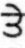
ਤੇ
